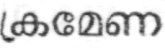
ക്രമേണ
